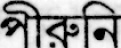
পীরুনি
